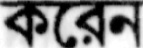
করেন
